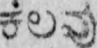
ಕೆಲವು
